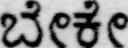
ಬೇಕೇ
